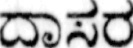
ದಾಸರ
